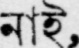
নাই,
